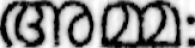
അമ്മ:
